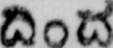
ದಿಂದ
